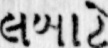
લબાટે
